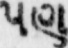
પણ
